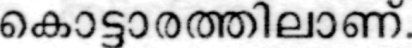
കൊട്ടാരത്തിലാണ്.
